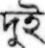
দুই
